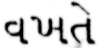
વખતે
